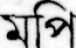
মপি
